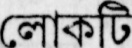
লোকটি
